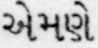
એમણે
